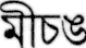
মীচঙ
